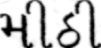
મીઠી
